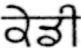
ਕੇਡੀ
